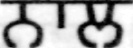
ਨਾਲ
